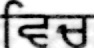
ਵਿਚ
